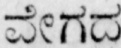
ವೇಗದ
